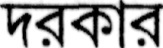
দরকার
